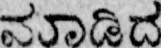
ಮಾಡಿದ
